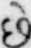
છે
